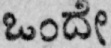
ಒಂದೇ
